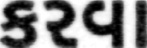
કરવા
